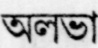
অলভা
